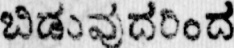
ಬಿಡುವುದರಿಂದ
